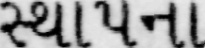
સ્થાપના
